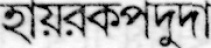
হায়রকপদুদা
